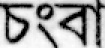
চংবা
